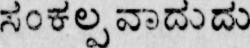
ಸಂಕಲ್ಪವಾದುದು
